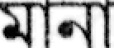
মানা
